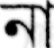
না
